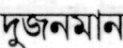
দুজনমান
